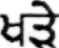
ਖੜੇ
